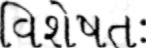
વિશેષતઃ
